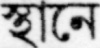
স্থানে
